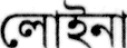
লোইনা
